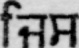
ਜਿਸ
